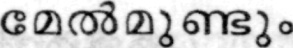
മേല്‍മുണ്ടും
